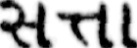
સત્તા
